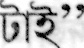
টাই”
